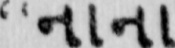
“નાના
